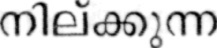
നില്ക്കുന്ന
